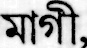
মাগী,
